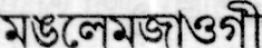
মঙলেমজাওগী
